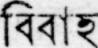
বিবাহ
